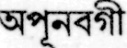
অপূনবগী
